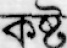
কষ্ট
